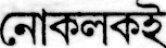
নোকলকই
